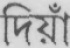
দিয়াঁ
